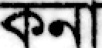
কনা
